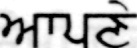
ਆਪਣੇ
